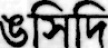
ঙসিদি
